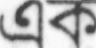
এক
